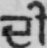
ਦੀ
